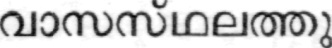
വാസസ്ഥലത്തു
